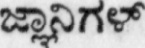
ಜ್ಞಾನಿಗಳ್
